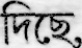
দিছে,
